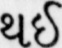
થઈ
